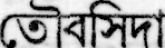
তৌবসিদা
